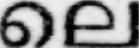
ലെ
